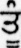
ਤੂੰ
